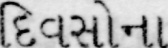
દિવસોના
